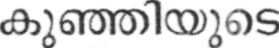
കുഞ്ഞിയുടെ
